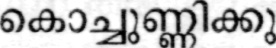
കൊച്ചുണ്ണിക്കു
